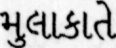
મુલાકાતે
